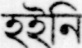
হইনি
